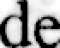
de
